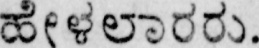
ಹೇಳಲಾರರು.
